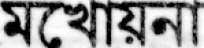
মখোয়না
